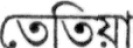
তেতিয়া
